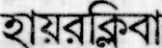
হায়নরক্লিবা
